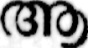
ആ
